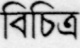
বিচিত্র
